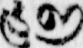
હજી
